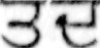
ਤਦ
